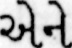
એને
